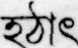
হঠাৎ
